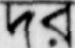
দর
